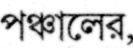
পঞ্চালের,
